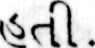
હતી.
